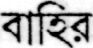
বাহির
